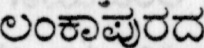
ಲಂಕಾಪುರದ
